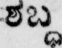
ಶಬ್ಧ
